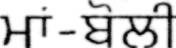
ਮਾਂ-ਬੋਲੀ
